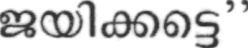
ജയിക്കട്ടെ"
